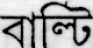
বাল্টি
